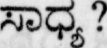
ಸಾಧ್ಯ?
